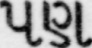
પણ
